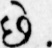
છે.
